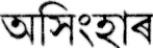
অসিংহাৰ
